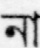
না
